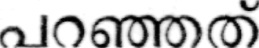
പറഞ്ഞത്
